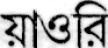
য়াওরি
